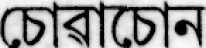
চোৱাচোন
